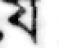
যে
